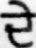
ਦੇ
